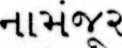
નામંજૂર
